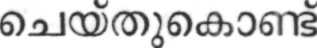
ചെയ്തുകൊണ്ട്
